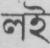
লই
